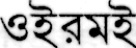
ওইরমই
